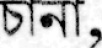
চানা,
